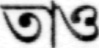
তাও
